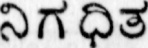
ನಿಗಧಿತ
